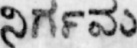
ನಿರ್ಗಮ
